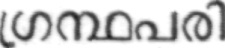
ഗ്രന്ഥപരി
